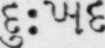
દુ:ખદ
